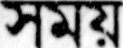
সময়
